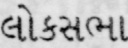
લોકસભા
